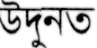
ঊদুনত
